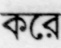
করে
